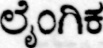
ಲೈಂಗಿಕ
